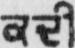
ਕਦੀ
